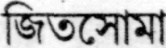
জিতসোমা
